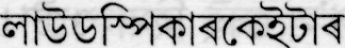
লাউডস্পিকাৰকেইটাৰ
